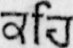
ਕਹਿ
